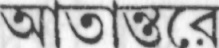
আতান্তরে
